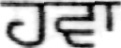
ਹਵਾ
